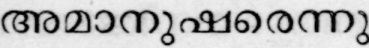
അമാനുഷരെന്നു
